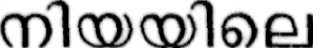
നിയയിലെ
